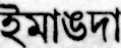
ইমাঙদা
